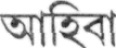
আহিবা
